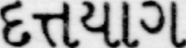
દત્તયાગ
